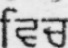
ਵਿਚ
